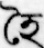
হৈ
